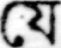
যে
